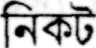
নিকট
